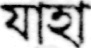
যাহা
